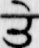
ਤੇ
